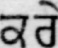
ਕਰੇ
